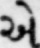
એ
